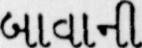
બાવાની
